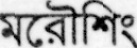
মরৌশিং
